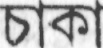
চাকা
